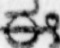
ಈ
